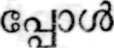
പ്പോള്‍
